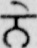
ਨੇ
